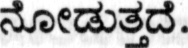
ನೋಡುತ್ತದೆ.
